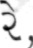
રે,
